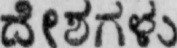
ದೇಶಗಳು
